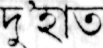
দু'হাত
